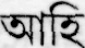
আহি
